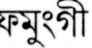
ফমুংগী
